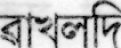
ৱাখলদি
